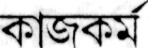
কাজকর্ম
